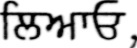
ਲਿਆਓ,
